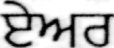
ਏਅਰ
